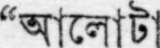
‘‘আলোটা
